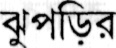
ঝুপড়ির
